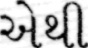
એથી
